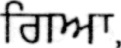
ਗਿਆ,
